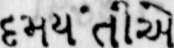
દમયંતીએ
